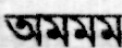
অমমম
